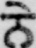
ਨੇ
